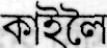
কাইলৈ
